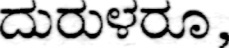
ದುರುಳರೂ,
